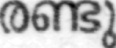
രണ്ടു
